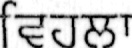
ਵਿਹਲਾ
